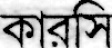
কারসি
